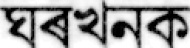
ঘৰখনক
